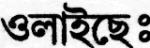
ওলাইছেঃ
